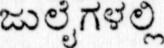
ಜುಲೈಗಳಲ್ಲಿ
